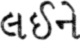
લઈને
